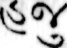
હજુ
